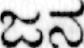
ಜನ
